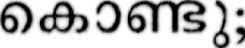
കൊണ്ടു;
